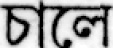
চালে
